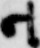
ન
